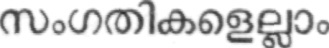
സംഗതികളെല്ലാം
